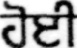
ਹੋਈ
